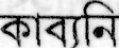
কাব্যনি
